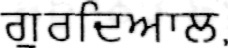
ਗੁਰਦਿਆਲ,
